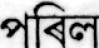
পৰিল
